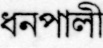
ধনপালী
